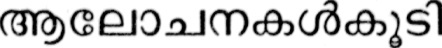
ആലോചനകള്‍കൂടി
